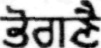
ਭੋਗਣੈ
